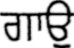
ਗਾਉ
